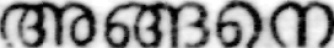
അങ്ങനെ
